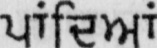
ਪਾਂਦਿਆਂ
